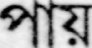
পায়
